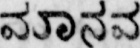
ಮಾನವ
